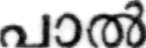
പാല്‍
